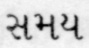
સમય
